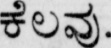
ಕೆಲವು.
